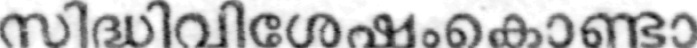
സിദ്ധിവിശേഷംകൊണ്ടാ
